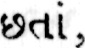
છતાં,
